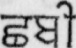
ਛਬੀ
